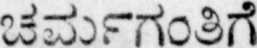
ಚರ್ಮಗಂತಿಗೆ
